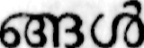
ങ്ങള്‍
